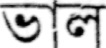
ভাল
